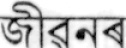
জীৱনৰ
